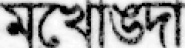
মখোঙদা
